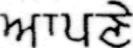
ਆਪਣੇ
